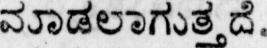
ಮಾಡಲಾಗುತ್ತದೆ.
